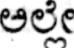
ಅಲ್ಲೇ
